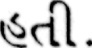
હતી.
